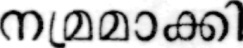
നമ്രമാക്കി
